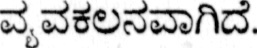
ವ್ಯವಕಲನವಾಗಿದೆ.
